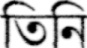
তিনি
